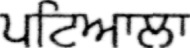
ਪਟਿਆਲਾ
